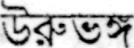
উরুভঙ্গ
